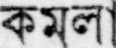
কমলা
